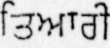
ਤਿਆਰੀ
